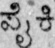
ಪೈಕಿ
